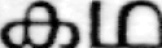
കഥ
